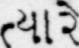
ત્યારે
